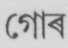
গোৰ
